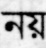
নয়
